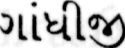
ગાંધીજી
